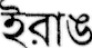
ইরাঙ
